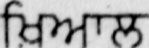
ਖ਼ਿਆਲ
